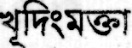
খূদিংমক্তা
